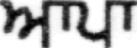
ਆਪਾ
